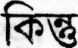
কিন্তু
